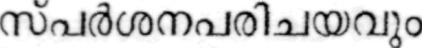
സ്പര്‍ശനപരിചയവും
